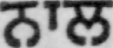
ਨਾਲ
